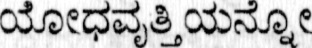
ಯೋಧವೃತ್ತಿಯನ್ನೋ
